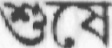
শুষে
